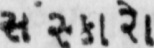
સંસ્કારો
